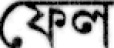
ফেল
